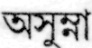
অসুম্না
